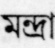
মন্দ্রা
